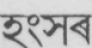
হংসৰ
